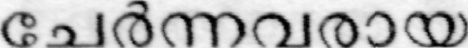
ചേര്‍ന്നവരായ
